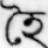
হৈ
